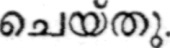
ചെയ്തു.
